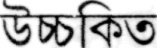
উচ্চকিত
